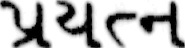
પ્રયત્ન
